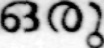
ഒരു
